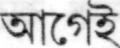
আগেই
